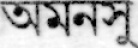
অমনসু
